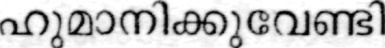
ഹുമാനിക്കുവേണ്ടി
